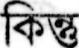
কিন্তু
